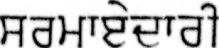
ਸਰਮਾਏਦਾਰੀ
